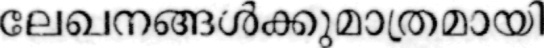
ലേഖനങ്ങള്‍ക്കുമാത്രമായി
